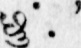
છું.'
